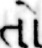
તો
